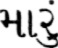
મારું
